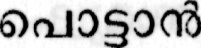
പൊട്ടാന്‍
